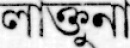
লাক্তুনা
